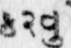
કરવું
